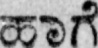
ಹಾಗೆ
